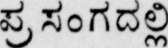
ಪ್ರಸಂಗದಲ್ಲಿ
